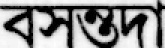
বসন্তদা
